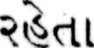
રહેતા
